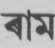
ৰাম
